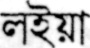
লইয়া
